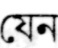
যেন
